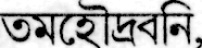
তমহৌদ্রবনি,
